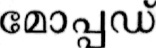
മോപ്പഡ്
